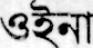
ওইনা
